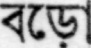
বড়ো
